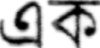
এক
